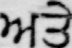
ਅਤੇ
